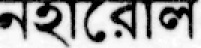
নহারোল
